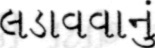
લડાવવાનું
